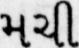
મચી
